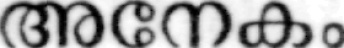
അനേകം
